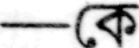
–কে
